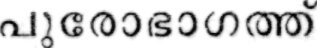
പുരോഭാഗത്ത്
